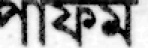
পাফম
